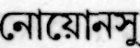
নোয়োনসু
